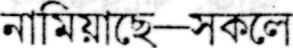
নামিয়াছে—সকলে
